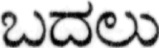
ಬದಲು
